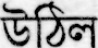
উঠিল
